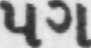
પગ
